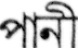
পানী
